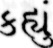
કહ્યું
